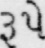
રૂપે
